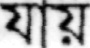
যায়
